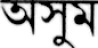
অসুম
